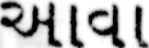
આવા
